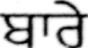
ਬਾਰੇ
